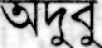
অদুবু
